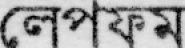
লেপফম
